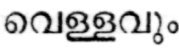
വെള്ളവും
